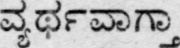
ವ್ಯರ್ಥವಾಗ್ತಾ
